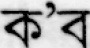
ক'ব
